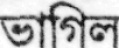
ভাগিল
